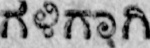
ಗಳಿಗಾಗಿ
